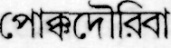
পোক্কদৌরিবা
